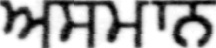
ਅਸਮਾਨ
